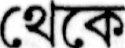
থেকে
